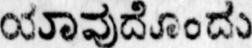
ಯಾವುದೊಂದು
